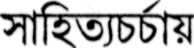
সাহিত্যচর্চায়
